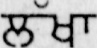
ਲੱਖਾ
